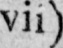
vii)
